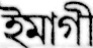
ইমাগী
